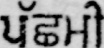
ਪੱਛਮੀ
